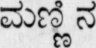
ಮಣ್ಣಿನ
